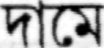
দামে
